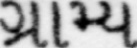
ગ્રામ્ય
